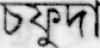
চফুদা
